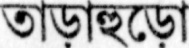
তাড়াহুড়ো
